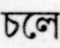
চলে
